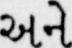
અને
